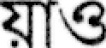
য়াও
